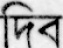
দিব
